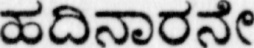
ಹದಿನಾರನೇ
